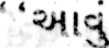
"આવું
